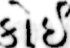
કોઈ
